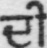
ਦੀ
